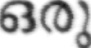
ഒരു
